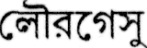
লৌরগেসু
